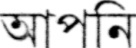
আপনি
